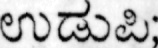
ಉಡುಪಿ;
